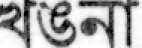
খঙনা
